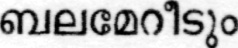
ബലമേറീടും
